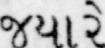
જ્યારે
